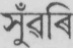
সুঁৱৰি
